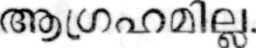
ആഗ്രഹമില്ല.
